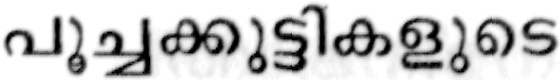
പൂച്ചക്കുട്ടികളുടെ
